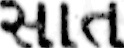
સાત
